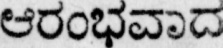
ಆರಂಭವಾದ
